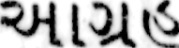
આગ્રહ
